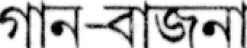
গান-বাজনা
